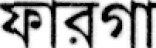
ফারগা
